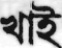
খাই
